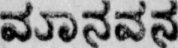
ಮಾನವನ
